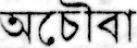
অচৌবা
